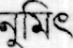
নুমিৎ
